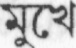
মুখে
